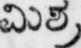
ಮಿಶ್ರ
